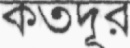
কতদূর
